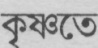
কৃষ্ণতে
